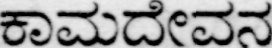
ಕಾಮದೇವನ
